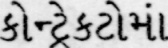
કોન્ટ્રેકટોમાં
